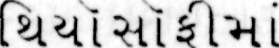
થિયૉસૉફીમાં
